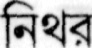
নিথর
